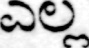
ಎಲ್ಲ
